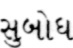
સુબોધ
